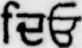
ਦਿਓ
